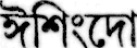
ঈশিংদো
